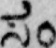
ಸಂ
